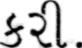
કરી.
